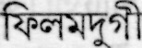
ফিলমদুগী
